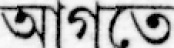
আগতে
